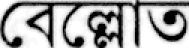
বেল্লোত
